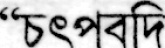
“চৎপবদি
